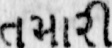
તમારી
